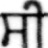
ਸੀ
